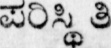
ಪರಿಸ್ಥಿತಿ
